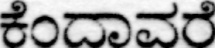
ಕೆಂದಾವರೆ
